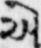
એ
